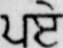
ਪਏ
